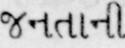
જનતાની
